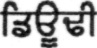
ਡਿਊਢੀ
